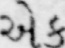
એક
